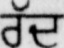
ਰੱਦ
